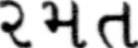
રમત
